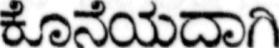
ಕೊನೆಯದಾಗಿ
